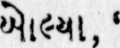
બોલ્યા,
